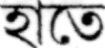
হাতে
